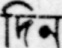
দিন
